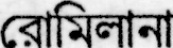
রোমিলনা
